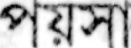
পয়সা
